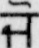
ਜੋ
